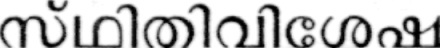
സ്ഥിതിവിശേഷ
